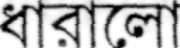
ধারালো
